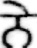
ਨੇ
